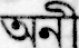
অনী
